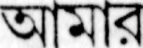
আমার
